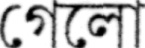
গেলো
